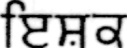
ਇਸ਼ਕ
